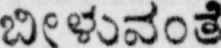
ಬೀಳುವಂತೆ
